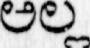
ಅಲ್ಲ
